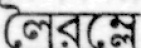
লৈরম্লে
